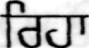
ਰਿਹਾ
